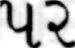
પર
